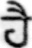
ਹੈ
